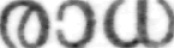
രാധ
